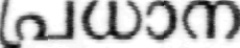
പ്രധാന
